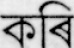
কৰি
